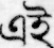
এই
